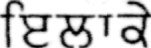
ਇਲਾਕੇ
